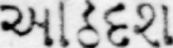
આઠદશ
